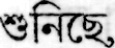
শুনিছে,
